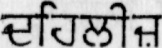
ਦਹਿਲੀਜ਼
